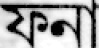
ফনা
